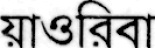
য়াওরিবা
